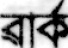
ৱার্ক
